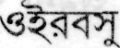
ওইরবসু
